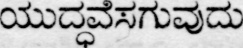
ಯುದ್ಧವೆಸಗುವುದು
